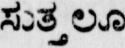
ಸುತ್ತಲೂ
